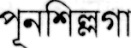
পূনশিল্লগা
